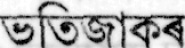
ভতিজাকৰ
